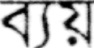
ব্যয়
